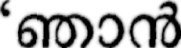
'ഞാന്‍
